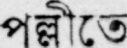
পল্লীতে
